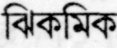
ঝিকমিক
